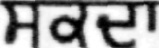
ਸਕਦਾ
